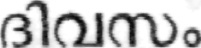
ദിവസം
